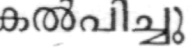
കല്‍പിച്ചു
